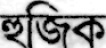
হুজিক
